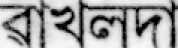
ৱাখলদা
